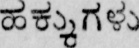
ಹಕ್ಕುಗಳು
